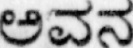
ಅವನ
